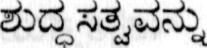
ಶುದ್ಧಸತ್ವವನ್ನು
